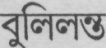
বুলিলন্ত
